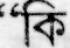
"কি
